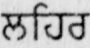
ਲਹਿਰ
